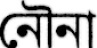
নৌনা
